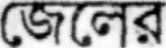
জেলের
